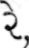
રે,
